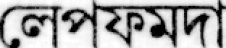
লেপফমদা
